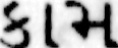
કામ
